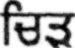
ਚਿੜ
